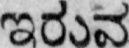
ಇರುವ
